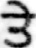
ਤੇ
